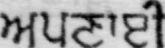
ਅਪਣਾਈ
